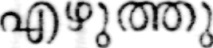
എഴുത്തു
